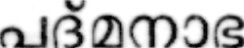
പദ്മനാഭ
